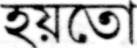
হয়তো
